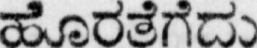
ಹೊರತೆಗೆದು
